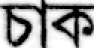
চাক
